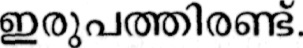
ഇരുപത്തിരണ്ട്.
